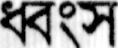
ধ্বংস
